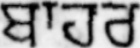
ਬਾਹਰ
